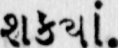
શક્યાં.
